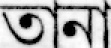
তানা
